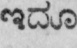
ಇದೂ
